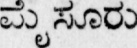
ಮೈಸೂರು
